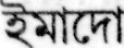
ইমাদো
